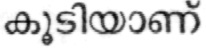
കൂടിയാണ്
